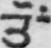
ਤੋਂ
